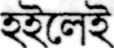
হইলেই
